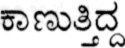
ಕಾಣುತ್ತಿದ್ದ
